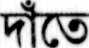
দাঁতে
